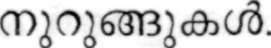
നുറുങ്ങുകള്‍.
